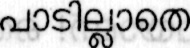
പാടില്ലാതെ
